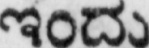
ಇಂದು
